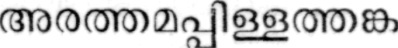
അരത്തമപ്പിള്ളത്തങ്ക
